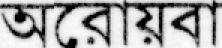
অরোয়বা
